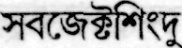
সবজেক্টশিংদু
